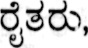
ರೈತರು,
